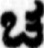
ಚ
